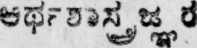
ಅರ್ಥಶಾಸ್ತ್ರಜ್ಞರ
